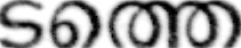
ടത്തെ
